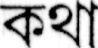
কথা
